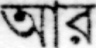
আর
